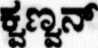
ಕ್ವಣ್ವನ್
